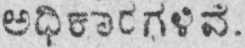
ಅಧಿಕಾರಗಳಿವೆ.
